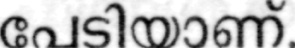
പേടിയാണ്.
